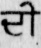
ਦੀ
